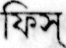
ফিস্
